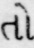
તો
